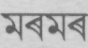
মৰমৰ
